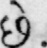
છે.
